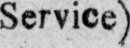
Service)
